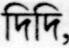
দিদি,
